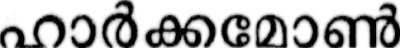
ഹാര്‍ക്കമോണ്‍
